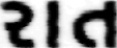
રાત
